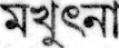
মখুৎনা
